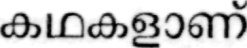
കഥകളാണ്
